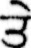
ਤੇ
